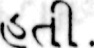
હતી.
